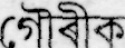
গৌৰীক
